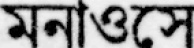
মনাওসে
